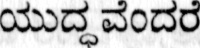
ಯುದ್ಧವೆಂದರೆ
